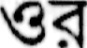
ওর
